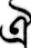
ঐ
